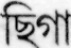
ছিগা
